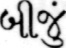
બીજું
